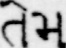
તેમ
